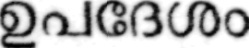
ഉപദേശം
